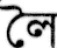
লৈ
